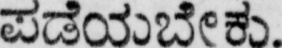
ಪಡೆಯಬೇಕು.
